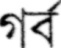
গর্ব
